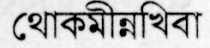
থোকমীন্নখিবা
